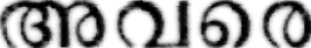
അവരെ
